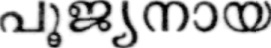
പൂജ്യനായ
